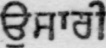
ਉਸਾਰੀ
